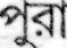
পুরা
